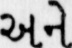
અને
